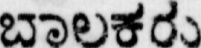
ಬಾಲಕರು
